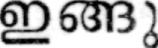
ഇങ്ങു
